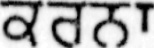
ਕਰਨਾ
